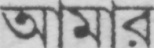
আমার
